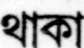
থাকা
